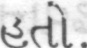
હતો.
